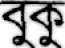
বুকু
